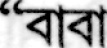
“বাবা
